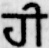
ਹੀ
